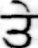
ਤੇ
